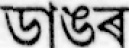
ডাঙৰ
